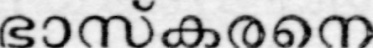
ഭാസ്കരനെ
